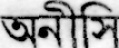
অনীসি
